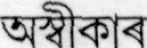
অস্বীকাৰ
